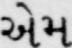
એમ
